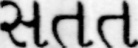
સતત
